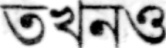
তখনও
